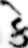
કે
